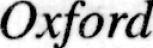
Oxford
